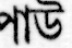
পাউ
